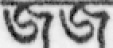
জজ
